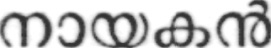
നായകന്‍
